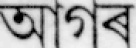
আগৰ
